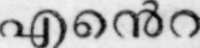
എന്റെ
